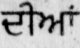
ਦੀਆਂ
